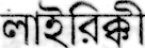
লাইরিক্কী
